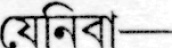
যেনিবা-
